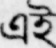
এই
